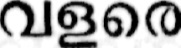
വളരെ
